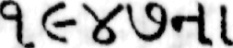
૧૯૪૭ના
